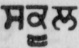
ਸਕੂਲ
